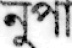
নুপা
